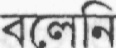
বলেনি
